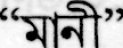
“মানী”
